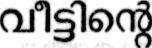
വീട്ടിന്റെ
